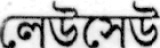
লেউসেউ
